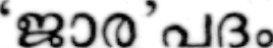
'ജാര'പദം
